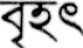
বৃহৎ
